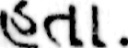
હતા.
